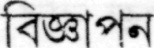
বিজ্ঞাপন
